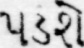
પડશે
